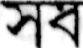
সব
